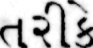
તરીકે
